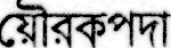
য়ৌরকপদা
